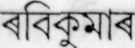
ৰবিকুমাৰ
